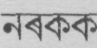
নৰকক
